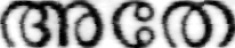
അതേ
